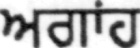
ਅਗਾਂਹ
